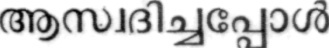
ആസ്വദിച്ചപ്പോള്‍
